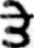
ਤੇ
